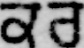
ਕਰ
